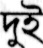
দুই
